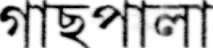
গাছপালা
